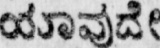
ಯಾವುದೇ
